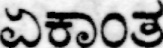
ಏಕಾಂತ
